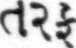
તરફ
